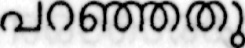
പറഞ്ഞതു
